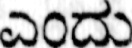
ಎಂದು
